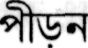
পীড়ন
